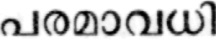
പരമാവധി
